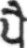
ਪੈ
